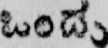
ಒಂದು
